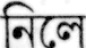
নিলে
